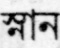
স্নান
